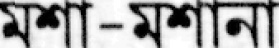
মশা-মশানা
